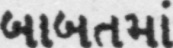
બાબતમાં
